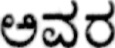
ಅವರ
